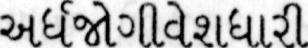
અર્ધજોગીવેશધારી
